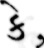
કે,
